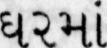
ઘરમાં
